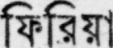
ফিরিয়া
